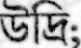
উদ্রি;
